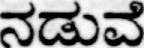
ನಡುವೆ
